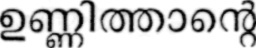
ഉണ്ണിത്താന്റെ
